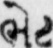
ભેટ
